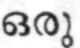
ഒരു
